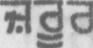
ਜ਼ਰੂਰ
